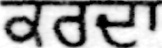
ਕਰਦਾ
